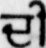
ਦੀ
